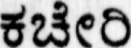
ಕಚೇರಿ
